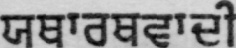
ਯਥਾਰਥਵਾਦੀ
